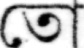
তো
